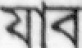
যাব
